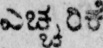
ಎಚ್ಚರಿಕೆ
